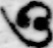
ও
